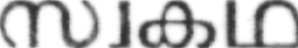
സ്വകഥ
